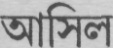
আসিল
